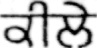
ਕੀਲੇ
